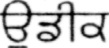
ਉਡੀਕ
